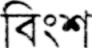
বিংশ
